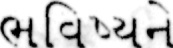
ભવિષ્યને
